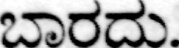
ಬಾರದು.
